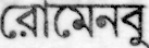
রোমেনবু
